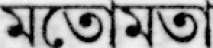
মতোমতা
